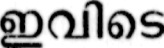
ഇവിടെ
